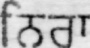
ਨਿਰਾ
